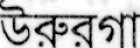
উরুরগা
